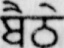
ਬੈਠੇ
